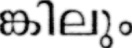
ങ്കിലും
